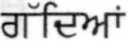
ਗੱਦਿਆਂ
